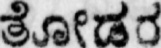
ತೋಡರ
